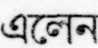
এলেন
